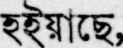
হইয়াছে,
